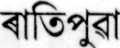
ৰাতিপুৱা
